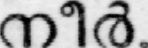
നീര്‍.
